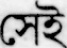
সেই
